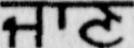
ਜਾਣ
